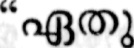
“ഏതു
